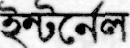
ইন্টর্নেল
